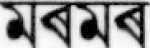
মৰমৰ
